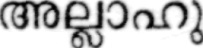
അല്ലാഹു
